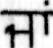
ਜਾਂ
